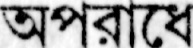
অপরাধে
